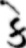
કે
